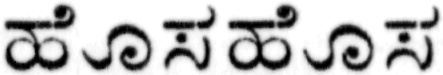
ಹೊಸಹೊಸ
